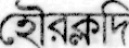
হৌরক্লদি
